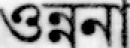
ওন্ননা
